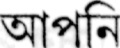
আপনি
